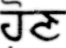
ਹੋਣ
